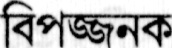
বিপজ্জনক
